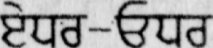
ਏਧਰ-ਓਧਰ
